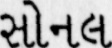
સોનલ
